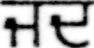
ਜਦ
